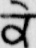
ਕੇ
